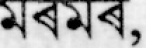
মৰমৰ,
